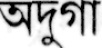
অদুগা
